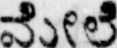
ಮೇಲೆ
